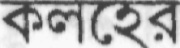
কলহের
